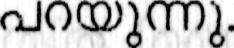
പറയുന്നു.
